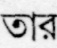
তার
